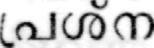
പ്രശ്ന
